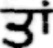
ਤਾਂ
